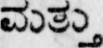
ಮತ್ತು
